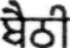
ਬੈਠੀ
